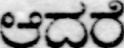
ಆದರೆ
